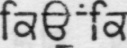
ਕਿਉਂਕਿ
